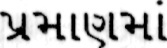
પ્રમાણમાં
